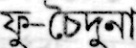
ফু-চৈদুনা
